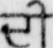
ਦੀ
